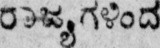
ರಾಜ್ಯಗಳಿಂದ
